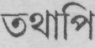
তথাপি
